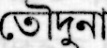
তৌদুনা
